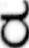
ರ
